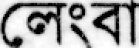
লেংবা
